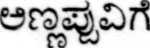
ಅಣ್ಣಪ್ಪುವಿಗೆ
